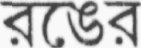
রঙের
